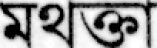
মথক্তা
